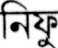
নিফু
